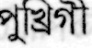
পুখ্রিগী
